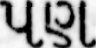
પણ
